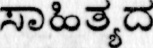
ಸಾಹಿತ್ಯದ
